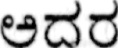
ಅದರ
